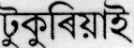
টুকুৰিয়াই
